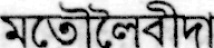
মতৌলৈবীদা
